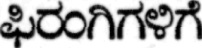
ಫಿರಂಗಿಗಳಿಗೆ
